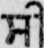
ਸੀ
